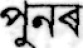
পুনৰ
